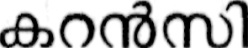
കറന്‍സി
